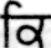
ਕਿ
